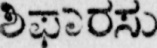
ಶಿಫಾರಸು
